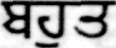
ਬਹੁਤ
